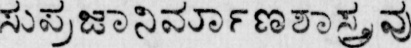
ಸುಪ್ರಜಾನಿರ್ಮಾಣಶಾಸ್ತ್ರವು
